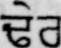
ਢੇਰ
